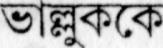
ভাল্লুককে
